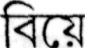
বিয়ে
